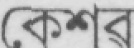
কেশৱ
